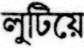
লুটিয়ে
